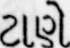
ટાણે
